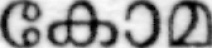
കോമ
